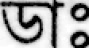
ডাঃ
